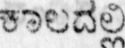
ಕಾಲದಲ್ಲಿ
